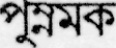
পুম্নমক
